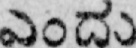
ಎಂದು
